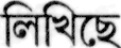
লিখিছে
